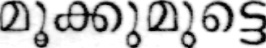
മൂക്കുമുട്ടെ
